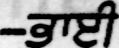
-ਭਾਈ
